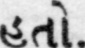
હતો.
